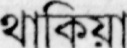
থাকিয়া
